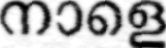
നാളെ
